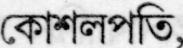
কোশলপতি,
